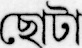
ছোটা
